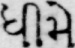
ધીમે
